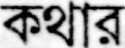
কথার
